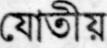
যোতীয়
